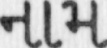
નામ
